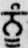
ਨੂੰ
